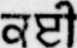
ਕਈ
